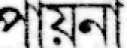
পায়না
